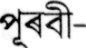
পূৰবী-
